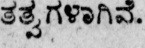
ತತ್ವಗಳಾಗಿವೆ.
